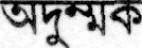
অদুম্মক
